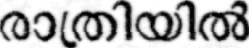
രാത്രിയില്‍
